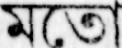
মতো
